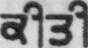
ਕੀਤੀ
